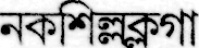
নকশিল্লক্লগা
